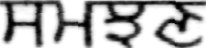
ਸਮਝਣ
